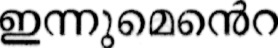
ഇന്നുമെന്റെ
